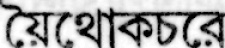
য়ৈথোকচরে
